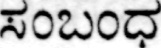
ಸಂಬಂಧ
